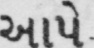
આપે
